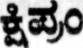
ಕ್ಷಿಪ್ರ೦
